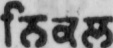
ਨਿਕਲ
